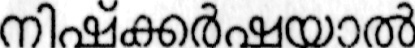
നിഷ്ക്കര്‍ഷയാല്‍
